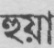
হুয়া
